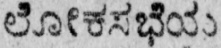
ಲೋಕಸಭೆಯ
